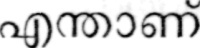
എന്താണ്
